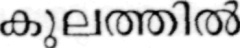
കുലത്തില്‍
